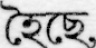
হৈছে,
